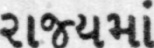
રાજ્યમાં
